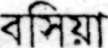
বসিয়া
